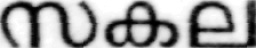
സകല
